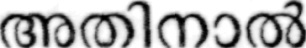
അതിനാല്‍
